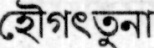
হৌগৎতুনা
